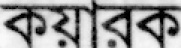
কয়ারক
